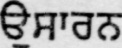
ਉਸਾਰਨ
